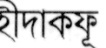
হীদাকফূ
